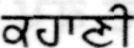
ਕਹਾਣੀ
